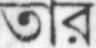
তার
